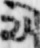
એ
